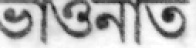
ভাওনাত
